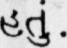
હતું.
